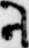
ને
